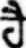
ਹੈ
